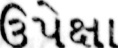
ઉપેક્ષા
